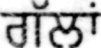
ਗੱਲਾਂ
